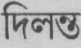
দিলন্ত
